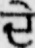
ਦੇ
